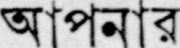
আপনার
